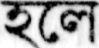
হলে
